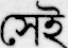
সেই
